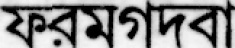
ফরমগদবা
